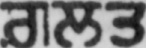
ਗ਼ਲਤ
